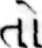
તો
